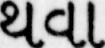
થવા
